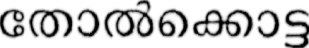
തോല്‍ക്കൊട്ട
